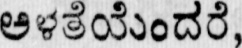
ಅಳತೆಯೆಂದರೆ,
